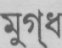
মুগধ
